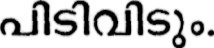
പിടിവിടും.
